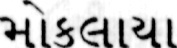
મોકલાયા
